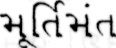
મૂર્તિમંત
